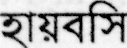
হায়বসি
